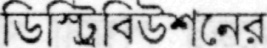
ডিস্ট্রিবিউশনের
